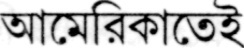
আমেরিকাতেই
